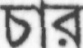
চার
